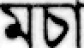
মচা
